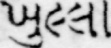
ખુલ્લા
